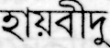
হায়বীদু
